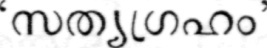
‘സത്യഗ്രഹം'
